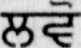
ਲਵੋ
